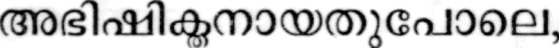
അഭിഷിക്തനായതുപോലെ,
